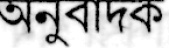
অনুবাদক
